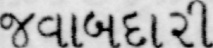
જવાબદારી
